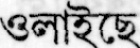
ওলাইছে
